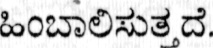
ಹಿಂಬಾಲಿಸುತ್ತದೆ.
